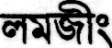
লমজীং
